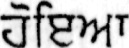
ਹੋਇਆ
